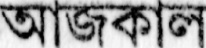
আজকাল
